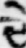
ਦੇ
